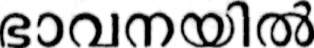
ഭാവനയില്‍
